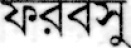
ফরবসু
